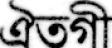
ঐতগী
